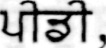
ਪੀਡੀ,
